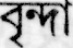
বৃন্দা
